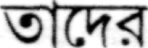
তাদের
